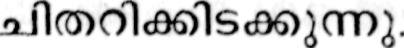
ചിതറിക്കിടക്കുന്നു.
